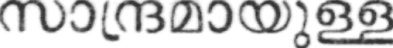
സാന്ദ്രമായുള്ള
